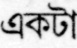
একটা
